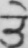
ਤੇ
